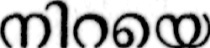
നിറയെ
